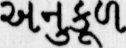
અનુકૂળ
